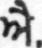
ਐ,
